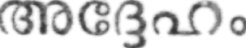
അദ്ദേഹം
